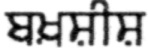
ਬਖ਼ਸ਼ੀਸ਼
